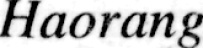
Haorang
